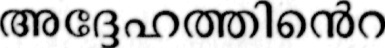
അദ്ദേഹത്തിന്റെ
